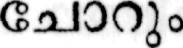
ചോറും
